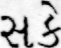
સકે
